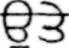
ਉਤੇ
